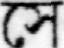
সে
